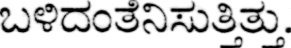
ಬಳಿದಂತೆನಿಸುತ್ತಿತ್ತು.
